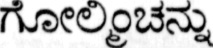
ಗೋಲ್ಮಿಂಚನ್ನು
